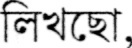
লিখছো,
